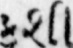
કશી
